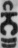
ਨੂੰ
